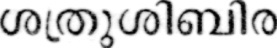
ശത്രുശിബിര
